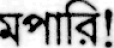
মপারি!
